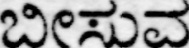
ಬೀಸುವ
